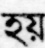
হয়
